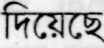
দিয়েছে
